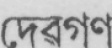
দেৱগণ
